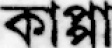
কাপ্পা
